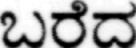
ಬರೆದ
